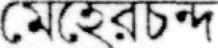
মেহেরচন্দ
